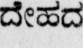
ದೇಹದ
